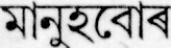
মানুহবোৰ
